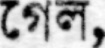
গেল,
